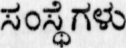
ಸಂಸ್ಥೆಗಳು
